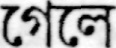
গেলে
